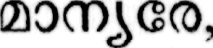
മാന്യരേ,
